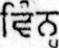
ਵਿੰਨ੍ਹ
